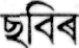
ছবিৰ
